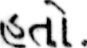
હતો.
